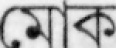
মোক
